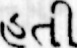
હતી
